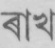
ৰাখ
